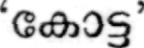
‘കോട്ട’
